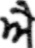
ਐ
